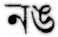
নঙ
